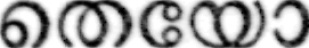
തെയോ
